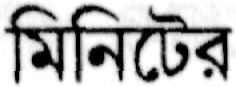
মিনিটের
